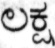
ಲಕ್ಷ
